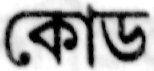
কোড
